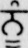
ਨੂੰ
